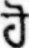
ਹੋ
